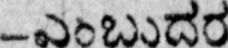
-ಎಂಬುದರ
